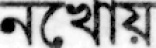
নখোয়
